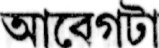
আবেগটা
